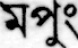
মপুং
